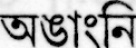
অঙাংনি
